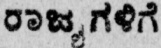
ರಾಜ್ಯಗಳಿಗೆ
